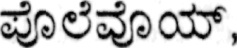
ಪೊಲೆವೊಯ್,
